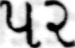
પર
